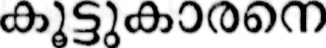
കൂട്ടുകാരനെ
